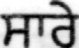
ਸਾਰੇ
